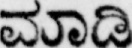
ಮಾಡಿ
